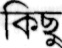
কিছু
